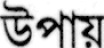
উপায়
